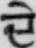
ਦੇ
